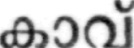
കാവ്
